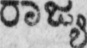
ರಾಜ್ಯ
